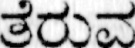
ತೆರುವ
